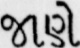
જાણે
